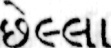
છેલ્લા
